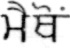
ਮੈਥੋਂ
